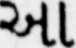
આ
